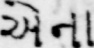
એના
